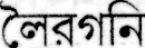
লৈরগনি
